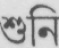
শুনি
